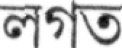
লগত
